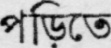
পড়িতে
